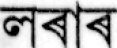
লৰাৰ
